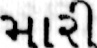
મારી
